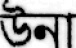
উনা
